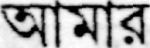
আমার
